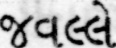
જવલ્લે
